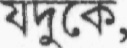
যদুকে,
